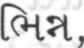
ભિન્ન,
